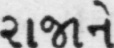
રાજાને
